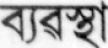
ব্যৱস্থা
